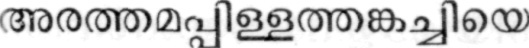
അരത്തമപ്പിള്ളത്തങ്കച്ചിയെ
